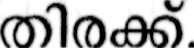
തിരക്ക്.
